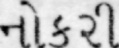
નોકરી
